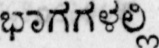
ಭಾಗಗಳಲ್ಲಿ
